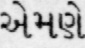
એમણે
